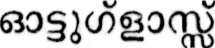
ഓട്ടുഗ്ളാസ്സ്
